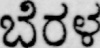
ಬೆರಳ
